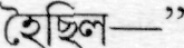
হৈছিল-"
